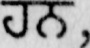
ਹਨ,
